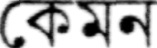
কেমন
